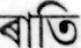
ৰাতি
